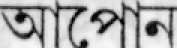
আপোন
